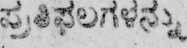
ಪ್ರತಿಫಲಗಳನ್ನು
